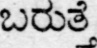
ಬರುತ್ತೆ
